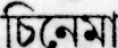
চিনেমা
